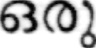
ഒരു
